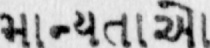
માન્યતાઓ
